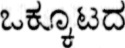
ಒಕ್ಕೂಟದ
